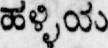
ಹಳ್ಳಿಯ
